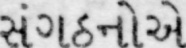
સંગઠનોએ
